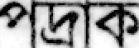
পদ্রাক
